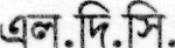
এল.দি.সি.
